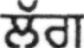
ਲੱਗ
